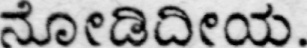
ನೋಡಿದೀಯ.
